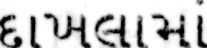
દાખલામાં
